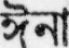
ঈনা
